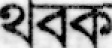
থবক
